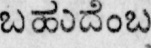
ಬಹುದೆಂಬ
